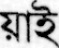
য়াই
